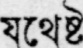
যথেষ্ট
